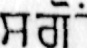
ਸਗੋਂ
